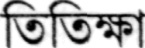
তিতিক্ষা
